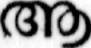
ആ
